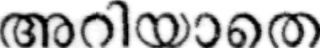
അറിയാതെ
